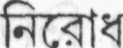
নিরোধ
